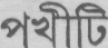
পখীটি
